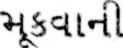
મૂકવાની
